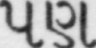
પણ
